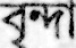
বৃন্দা
